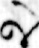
જે
